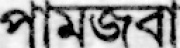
পামজবা
